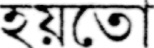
হয়তো
